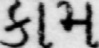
કામ
